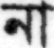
না
